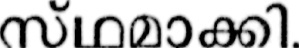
സ്ഥമാക്കി.
